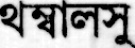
থম্বালসু
